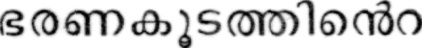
ഭരണകൂടത്തിന്റെ
